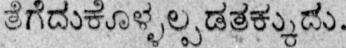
ತೆಗೆದುಕೊಳ್ಳಲ್ಪಡತಕ್ಕುದು.
